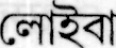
লোইবা
